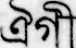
ঐগী
